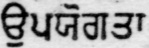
ਉਪਯੋਗਤਾ
